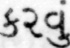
કરવું
